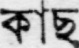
কাছ
